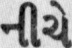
નીચે
